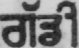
ਗੱਡੀ
